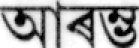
আৰম্ভ
